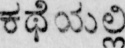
ಕಥೆಯಲ್ಲಿ
